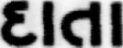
દાતા
